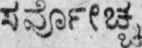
ಸರ್ವೋಚ್ಚ
